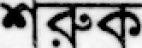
শরুক
